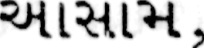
આસામ,
